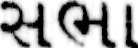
સભા
